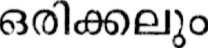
ഒരിക്കലും
